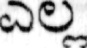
ಎಲ್ಲ
